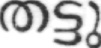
തട്ടു
